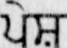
ਪੇਸ਼
